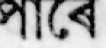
পাৰে
